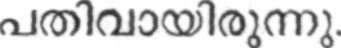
പതിവായിരുന്നു.
